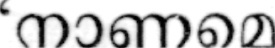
‘നാണമെ
